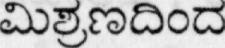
ಮಿಶ್ರಣದಿಂದ
